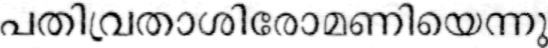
പതിവ്രതാശിരോമണിയെന്നു
